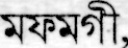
মফমগী,
